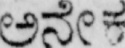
ಅನೇಕ
